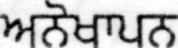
ਅਨੋਖਾਪਨ
